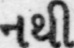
નથી
